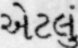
એટલું
